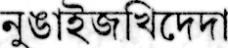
নুঙাইজখিদেদা
